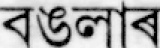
বঙলাৰ
